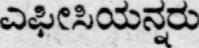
ಎಫೀಸಿಯನ್ನರು
